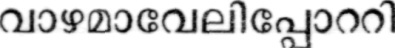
വാഴമാവേലിപ്പോററി
